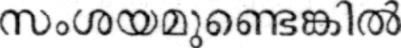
സംശയമുണ്ടെങ്കില്‍
